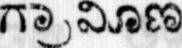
ಗ್ರಾಮೀಣ
